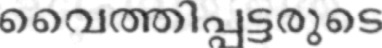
വൈത്തിപ്പട്ടരുടെ
